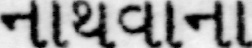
નાથવાના
